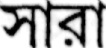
সারা
